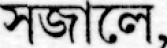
সজালে,
